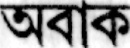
অবাক
